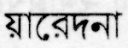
য়ারেদনা
